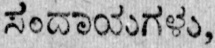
ಸಂದಾಯಗಳು,
